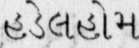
હડેલહોમ
